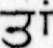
ਤਾਂ
